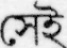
সেই
